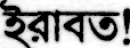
ইরাবত!
